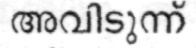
അവിടുന്ന്
